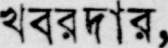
খবরদার,
